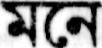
মনে
